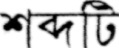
শব্দটি
